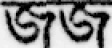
জজ
